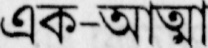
এক-আত্মা
